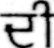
ਦੀ
